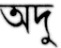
অদু
